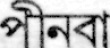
পীনবা
